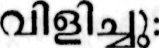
വിളിച്ചു:
